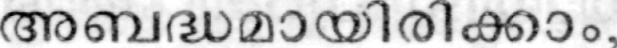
അബദ്ധമായിരിക്കാം,
